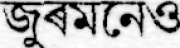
জুৰমনেও
